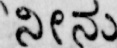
ನೀನು
